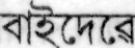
বাইদেৱে
